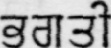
ਭਗਤੀ
